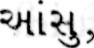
આંસુ,
